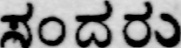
ಸಂದರು
